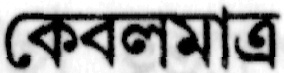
কেবলমাত্র
